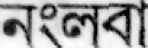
নংলবা
